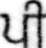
ਪੀ
